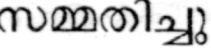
സമ്മതിച്ചു
